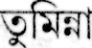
তুমিন্না
